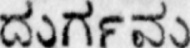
ದುರ್ಗಮ
